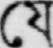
যে
